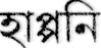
হাপ্পনি
